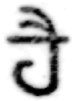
ਹੈ
